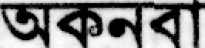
অকনবা
